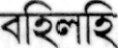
বহিলহি
